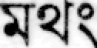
মথং
